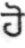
ਹੋ
